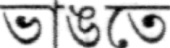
ভাঙতে
